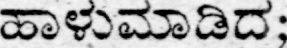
ಹಾಳುಮಾಡಿದ;
